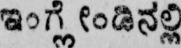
ಇಂಗ್ಲೇಂಡಿನಲ್ಲಿ
